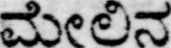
ಮೇಲಿನ
